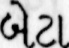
બેટા
